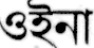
ওইনা
